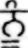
ਨੂੰ
